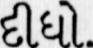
દીધો.
